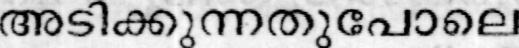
അടിക്കുന്നതുപോലെ
